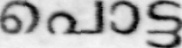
പൊട്ട
